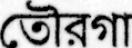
তৌরগা
